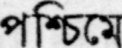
পশ্চিমে
